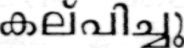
കല്പിച്ചു
